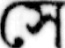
সে
